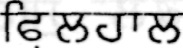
ਫ਼ਿਲਹਾਲ
